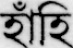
হাঁহি
